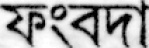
ফংবদা
